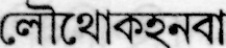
লৌথোকহনবা
